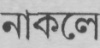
নাকলে
